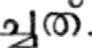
ച്ചത്.
